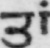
ਤਾਂ
